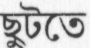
ছুটতে
